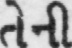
તેની
